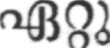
ഏറ്റു
